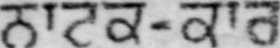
ਨਾਟਕ-ਕਾਰ
